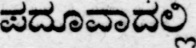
ಪದೂವಾದಲ್ಲಿ
